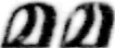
മമ
